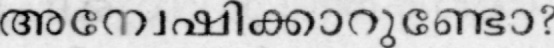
അന്വേഷിക്കാറുണ്ടോ?
